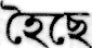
হৈছে
